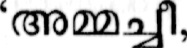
‘അമ്മച്ചീ,
